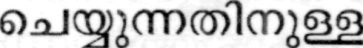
ചെയ്യുന്നതിനുള്ള
